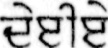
ਦੇਈਏ
